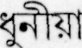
ধুনীয়া
